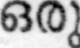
ഒരു
